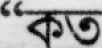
"কত
